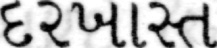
દરખાસ્ત
